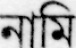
নামি
